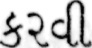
કરવી
